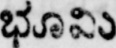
ಭೂಮಿ
